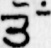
ਤੋਂ
